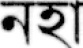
নহা
